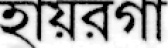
হায়রগা
